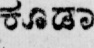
ಕೂಡಾ
